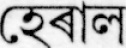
হেৰাল
